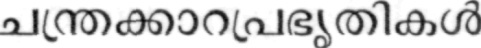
ചന്ത്രക്കാറപ്രഭൃതികള്‍
